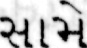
સામે
